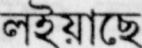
লইয়াছে
